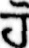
ਹੋ
